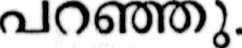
പറഞ്ഞു.
